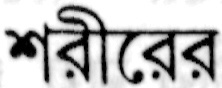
শরীরের
